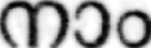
നാം
